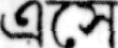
এসে
